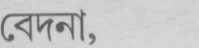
বেদনা,
